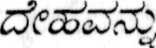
ದೇಹವನ್ನು
